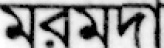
মরমদা
